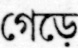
গেড়ে
